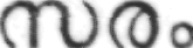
സരം
